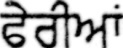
ਫੇਰੀਆਂ
